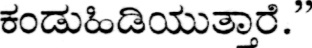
ಕಂಡುಹಿಡಿಯುತ್ತಾರೆ."
